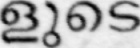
ളുടെ
